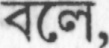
বলে,
